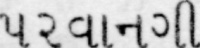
પરવાનગી
